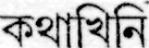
কথাখিনি
